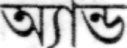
অ্যান্ড
